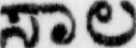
ಸಾಲ
